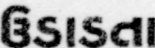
ઉડાડતા
